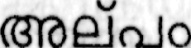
അല്പം
